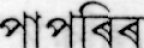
পাপৰিৰ
